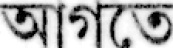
আগতে
